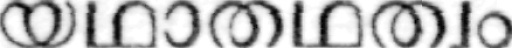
യഥാതഥത്വം
